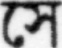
সে
